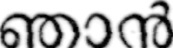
ഞാന്‍
